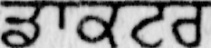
ਡਾਕਟਰ
